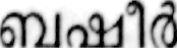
ബഷീര്‍
